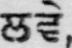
ਲਵੇ,
